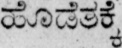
ಹೊಡೆತಕ್ಕೆ
